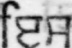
ਇਸ
